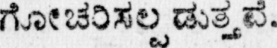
ಗೋಚರಿಸಲ್ಪಡುತ್ತವೆ.
